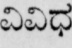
ವಿವಿಧ
